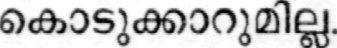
കൊടുക്കാറുമില്ല.
